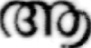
ആ
